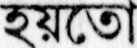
হয়তো
